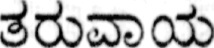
ತರುವಾಯ
